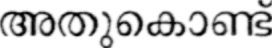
അതുകൊണ്ട്
